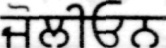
ਜੋਲੀਓਨ
